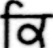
ਕਿ
